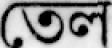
তেল
